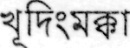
খূদিংমক্কা
